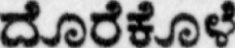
ದೊರೆಕೊಳೆ
